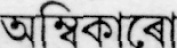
অম্বিকাৰো
